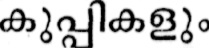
കുപ്പികളും
